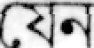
যেন
